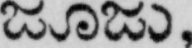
ಜೂಜು,
